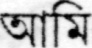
আমি
